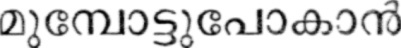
മുമ്പോട്ടുപോകാന്‍
